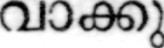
വാക്കു
